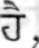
ਹੈ,
